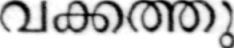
വക്കത്തു
